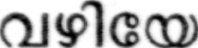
വഴിയേ
